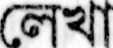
লেখা
